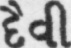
દૈવી
